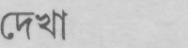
দেখা
